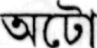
অটো
